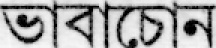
ভাবাচোন
